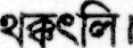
থক্কৎলি।
